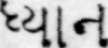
ધ્યાન
